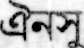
ঐনসু
